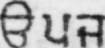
ਉਪਜ
